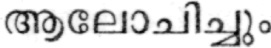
ആലോചിച്ചും
